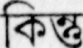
কিন্তু
